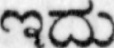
ಇದು
